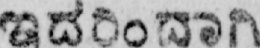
ಇದರಿಂದಾಗಿ
